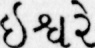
ઇશ્વરે
